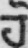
ਹੋ
